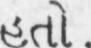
હતો.
